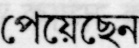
পেয়েছেন
